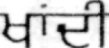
ਖਾਂਦੀ
